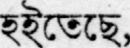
হইতেছে,
